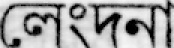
লেংদনা
